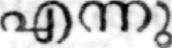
എന്നു
